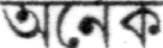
অনেক
